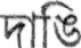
দাঙি
